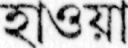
হাওয়া
